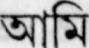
আমি
